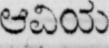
ಆವಿಯ
